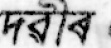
দেৱীৰ
